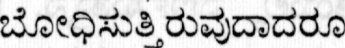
ಬೋಧಿಸುತ್ತಿರುವುದಾದರೂ
